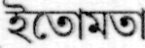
ইতোমতা
